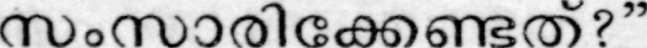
സംസാരിക്കേണ്ടത്?”
